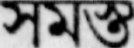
সমস্ত
